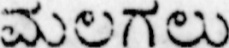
ಮಲಗಲು
